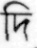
দি
